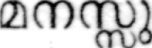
മനസ്സു
